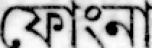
ফোংনা
